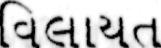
વિલાયત
